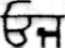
ਓਜ
